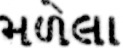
મળેલા
